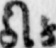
ઠીક
